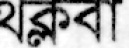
থক্লবা
